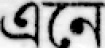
এনে
